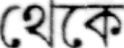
থেকে
